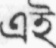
এই
